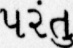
પરંતુ
